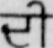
ਦੀ
